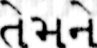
તેમને
